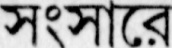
সংসারে
